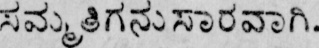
ಸಮ್ಮತಿಗನುಸಾರವಾಗಿ.
